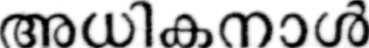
അധികനാള്‍
